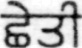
ਛੇਤੀ
